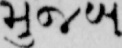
મુજબ
